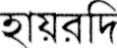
হায়রদি
